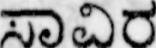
ಸಾವಿರ
